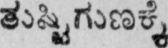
ತುಷ್ಟಿಗುಣಕ್ಕೆ
